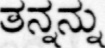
ತನ್ನನ್ನು
